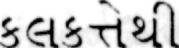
કલકત્તેથી
